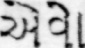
એવો
